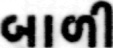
બાળી
